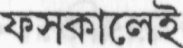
ফসকালেই
